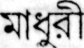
মাধুরী
